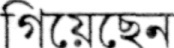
গিয়েছেন
